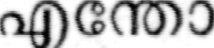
എന്തോ
